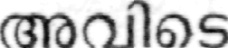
അവിടെ
